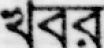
খবর
